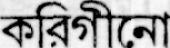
করিগীনো
